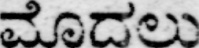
ಮೊದಲು
